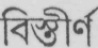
বিস্তীৰ্ণ
